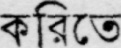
করিতে
